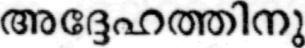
അദ്ദേഹത്തിനു
